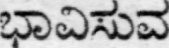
ಭಾವಿಸುವ
